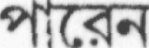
পারেন
